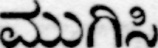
ಮುಗಿಸಿ
